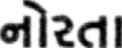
નોરતા
